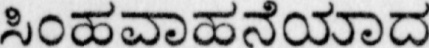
ಸಿಂಹವಾಹನೆಯಾದ
